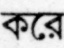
করে
